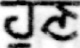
ਹੁਣ
